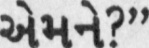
એમને?”
